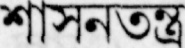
শাসনতন্ত্র
